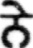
ਨੇ
